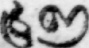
હજી
